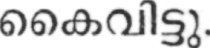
കൈവിട്ടു.
